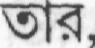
তার,
